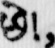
છો,
